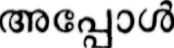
അപ്പോള്‍
